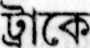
ট্রাকে
